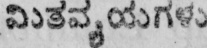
ಮಿತವ್ಯಯಗಳು
